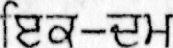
ਇਕ-ਦਮ
